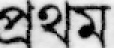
প্রথম
